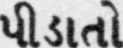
પીડાતો
